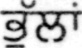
ਭੁੱਲਾਂ
